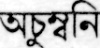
অচুম্বনি
